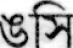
ঙসি
